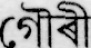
গৌৰী
